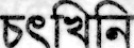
চৎখিনি
